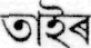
তাইৰ
